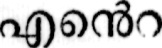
എന്റെ
